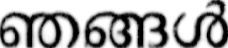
ഞങ്ങള്‍
